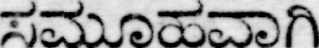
ಸಮೂಹವಾಗಿ
